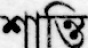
শান্তি
